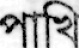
পাখি
